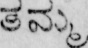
ತಮ್ಮ
